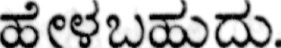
ಹೇಳಬಹುದು.
